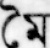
মৈ
